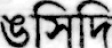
ঙসিদি
